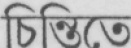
চিন্তিতে
